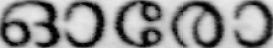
ഓരോ
